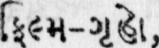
ફિલ્મ-ગૃહો,
